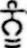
ਨੂੰ
